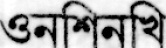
ওনশিনখি
